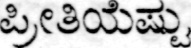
ಪ್ರೀತಿಯೆಷ್ಟು
